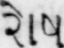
રોષ
